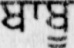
ਬਾਬੂ
